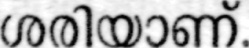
ശരിയാണ്.
